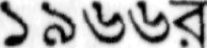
১৯৬৬র
